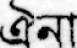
ঐনা
